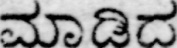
ಮಾಡಿದ
